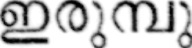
ഇരുമ്പു
